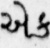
એક
